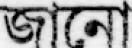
জানো
